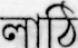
লাঠি
